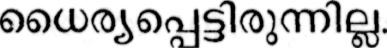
ധൈര്യപ്പെട്ടിരുന്നില്ല.
